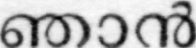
ഞാന്‍
